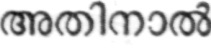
അതിനാല്‍
